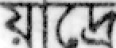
য়াদ্রে
